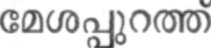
മേശപ്പുറത്ത്
